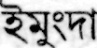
ইমুংদা
